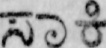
ಸಾಕಿ
